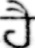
ਹੈ
